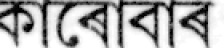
কাৰোবাৰ
